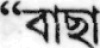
"বাছা
